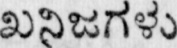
ಖನಿಜಗಳು
